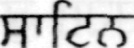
ਸਾਟਿਨ
